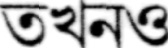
তখনও
